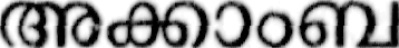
അക്കാംബ
